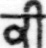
ਕੀ
